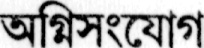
অগ্নিসংযোগ
